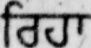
ਰਿਹਾ
